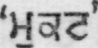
'ਮੁਕਟ'
